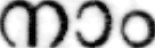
നാം
